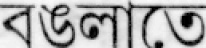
বঙলাতে
